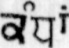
ਕੰਧਾਂ
